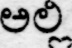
ಅಲ್ಲಿ
